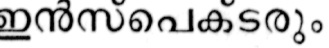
ഇന്‍സ്പെക്ടരും
